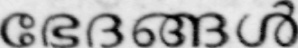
ഭേദങ്ങള്‍
